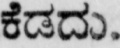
ಕೆಡದು.
